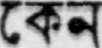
কেন
